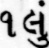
1લું
